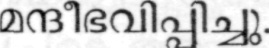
മന്ദീഭവിപ്പിച്ചു.
